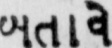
બતાવે
